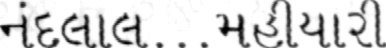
નંદલાલ...મહીયારી
